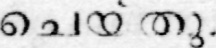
ചെയ്തു.
